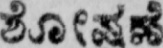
ಶೋಷಣೆ
